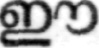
ഈ
